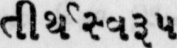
તીર્થસ્વરૂપ
